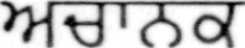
ਅਚਾਨਕ
